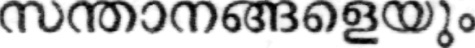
സന്താനങ്ങളെയും
